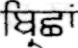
ਬ੍ਰਿਛਾਂ
